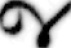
જ
